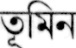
তূমিন
